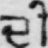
ਦੀ
